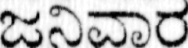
ಜನಿವಾರ
